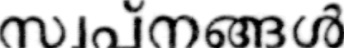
സ്വപ്നങ്ങള്‍
